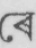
ৰে
